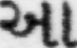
આ
